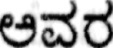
ಅವರ
